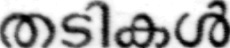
തടികള്‍
